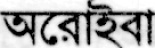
অরোইবা
